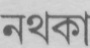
নথকা
